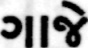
ગાજે
